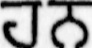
ਹਨ
